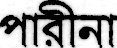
পারীনা
